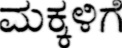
ಮಕ್ಕಳಿಗೆ
